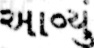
આવ્યું
